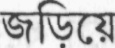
জড়িয়ে
